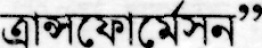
ত্রান্সফোর্মেসন”
